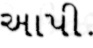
આપી.
